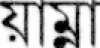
য়াম্না
